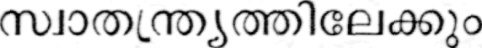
സ്വാതന്ത്ര്യത്തിലേക്കും
